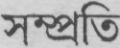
সম্প্ৰতি
